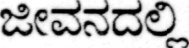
ಜೀವನದಲ್ಲಿ
